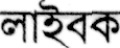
লাইবক
